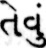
તેવું
